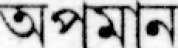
অপমান
